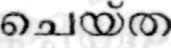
ചെയ്ത
